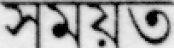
সময়ত
